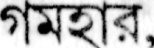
গমহার,
